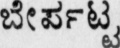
ಬೇರ್ಪಟ್ಟ
